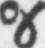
જ
